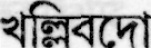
খল্লিবদো
